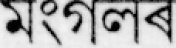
মংগলৰ
